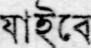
যাইবে
